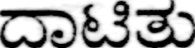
ದಾಟಿತು
